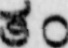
ತಂ
